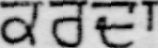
ਕਰਦਾ
